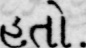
હતો.
